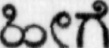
ಹೀಗೆ
